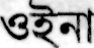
ওইনা
